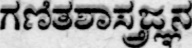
ಗಣಿತಶಾಸ್ತ್ರಜ್ಞನ
